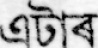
এটাৰ
